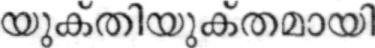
യുക്തിയുക്തമായി
